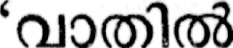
‘വാതില്‍
